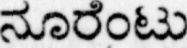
ನೂರೆಂಟು
